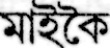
মাইকৈ
